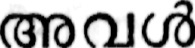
അവള്‍
